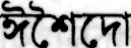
ঈশৈদো
